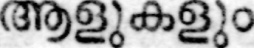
ആളുകളും
